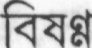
বিষণ্ণ
